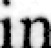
in
